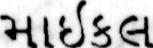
માઈકલ
